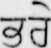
ਭਰੇ
